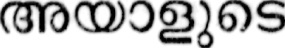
അയാളുടെ
